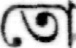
তো
